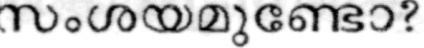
സംശയമുണ്ടോ?
